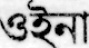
ওইনা
